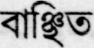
বাঞ্ছিত
